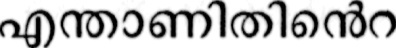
എന്താണിതിന്റെ
